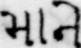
માને
